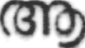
ആ
